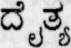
ದೈತ್ಯ
